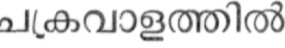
ചക്രവാളത്തില്‍
